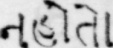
નહોતો
